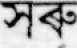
সৰু
